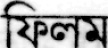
ফিলম
